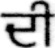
ਦੀ
